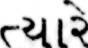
ત્યારે
